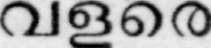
വളരെ
